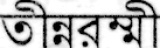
তীন্নরম্মী
